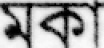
মকা
